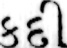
કદી
